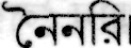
নৈনরি।
